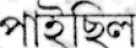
পাইছিল
